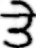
ਤੇ
